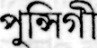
পুন্সিগী
